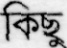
কিছু
